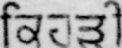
ਕਿਹੜੀ
